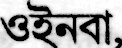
ওইনবা,
